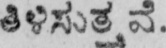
ತಿಳಿಸುತ್ತವೆ.
